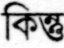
কিন্তু
